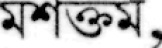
মশক্তম,
